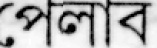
পেলাব
